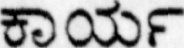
ಕಾರ್ಯ
